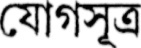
যোগসূত্র
